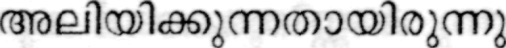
അലിയിക്കുന്നതായിരുന്നു
